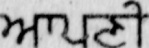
ਆਪਣੀ
